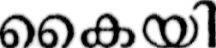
കൈയി
